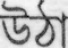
উঠা
